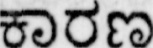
ಕಾರಣ
